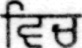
ਵਿਚ
